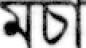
মচা
